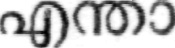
എന്താ
